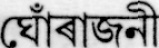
ঘোঁৰাজনী
